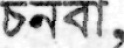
চনবা,
